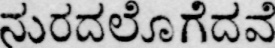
ನುರದಲೊಗೆದವೆ
